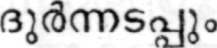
ദുര്‍ന്നടപ്പും
